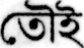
তৌই
